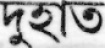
দুহাত
